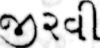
જીરવી
